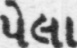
પેલા
